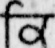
ਕਿ
